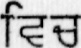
ਵਿਚ
